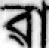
ৱা
